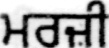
ਮਰਜ਼ੀ
